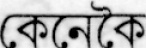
কেনেকৈ
